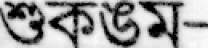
শুকঙম-
